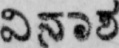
ವಿನಾಶ
